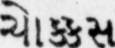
ચોક્કસ
